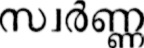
സ്വര്‍ണ്ണ
